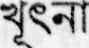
খূৎনা
